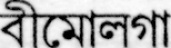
বীমোলগা
